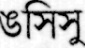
ঙসিসু
